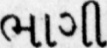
ભાગી
